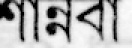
শান্নবা
